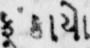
ફુંકાયો
